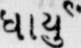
ધાર્યું
